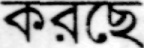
করছে
